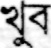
খুব
